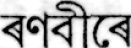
ৰণবীৰে
